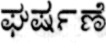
ಘರ್ಷಣೆ
